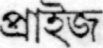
প্রাইজ
